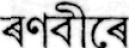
ৰণবীৰে
